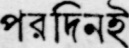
পরদিনই
